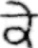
ਕੇ
